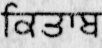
ਕਿਤਾਬ
